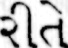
રીતે
